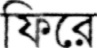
ফিরে
